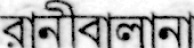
রানীবালানা
